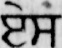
ਏਸ
